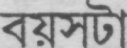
বয়সটা
